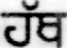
ਹੱਥ
